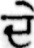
ਦੇ
